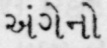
અંગેનો
